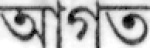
আগত
